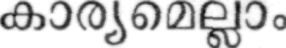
കാര്യമെല്ലാം
